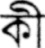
কী
